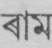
ৰাম
